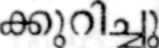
ക്കുറിച്ചു
